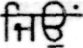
ਜਿਉਂ
